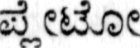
ಪ್ಲೇಟೋ
